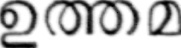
ഉത്തമ
